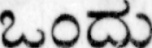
ಒಂದು
